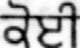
ਕੋਈ
